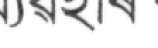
ব্যৱহাৰ
